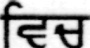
ਵਿਚ
